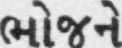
ભોજને
